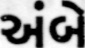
અંબે
